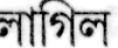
লাগিল
